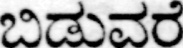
ಬಿಡುವರೆ
